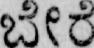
ಬೇರೆ
